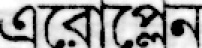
এরোপ্লেন
